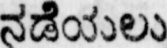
ನಡೆಯಲು
